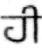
ਹੀ
